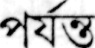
পর্যন্ত
